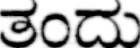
ತಂದು
